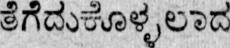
ತೆಗೆದುಕೊಳ್ಳಲಾದ
